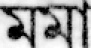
মমা
